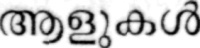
ആളുകള്‍
